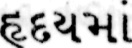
હૃદયમાં
